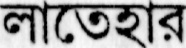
লাতেহার
